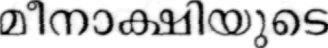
മീനാക്ഷിയുടെ
